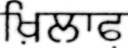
ਖ਼ਿਲਾਫ਼
